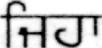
ਜਿਹਾ
